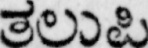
ತಲುಪಿ
